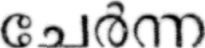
ചേര്‍ന്ന
